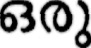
ഒരു
